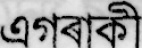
এগৰাকী
